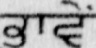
ਭਾਵੇਂ
